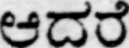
ಆದರೆ
